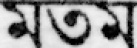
মতম
